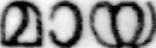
മായ
